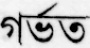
গর্ভত
